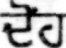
ਦੋਂਹ
